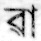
ৱা
